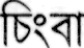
চিংবা
